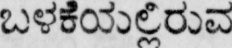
ಬಳಕೆಯಲ್ಲಿರುವ
